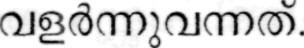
വളര്‍ന്നുവന്നത്.
